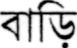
বাড়ি
